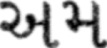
અમ
